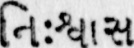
નિઃશ્વાસ
